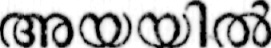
അയയില്‍
